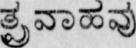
ತ್ಪ್ರವಾಹವು
